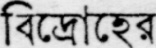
বিদ্রোহের
